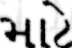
માટે
